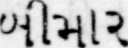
બીમાર
